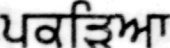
ਪਕੜਿਆ
